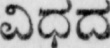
ವಿಧದ
